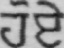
ਹੋਏ
